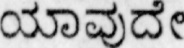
ಯಾವುದೇ
